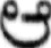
ಆ
